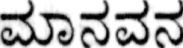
ಮಾನವನ
